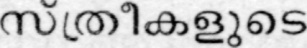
സ്ത്രീകളുടെ
